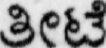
ತೀಟೆ
